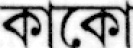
কাকো
